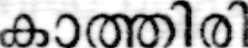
കാത്തിരി
